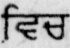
ਵਿਚ
